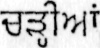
ਚੜ੍ਹੀਆਂ
